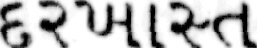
દરખાસ્ત
